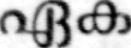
ഏക
